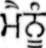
ਮੈਨੂੰ
